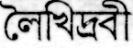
লৈখিদ্রবী
